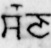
ਸੌਣ
